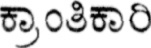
ಕ್ರಾಂತಿಕಾರಿ
